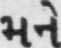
મને
